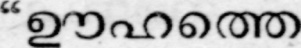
"ഊഹത്തെ
